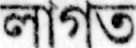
লাগত
